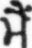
ਮੈਂ
